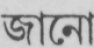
জানো
